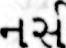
નર્સ
